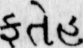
ફતેહ
